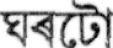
ঘৰটো
